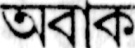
অবাক
